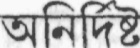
অনির্দিষ্ট
